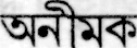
অনীমক
